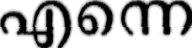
എന്നെ
